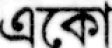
একো
